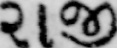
રાજી
